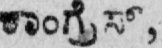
ಕಾಂಗ್ರೆಸ್,
